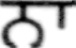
ਨਾ
